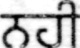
ਨਹੀ
